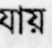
যায়
